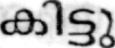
കിട്ടു
